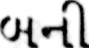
બની
